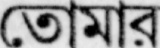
তোমার
